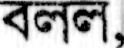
বলল,
